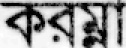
করম্না
